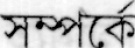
সম্পর্কে
